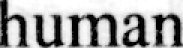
human
